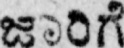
ಜಾರಿಗೆ
